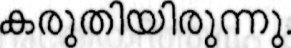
കരുതിയിരുന്നു.
